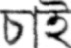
চাই
